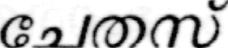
ചേതസ്
